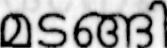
മടങ്ങി
